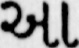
આ
